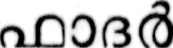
ഫാദര്‍
